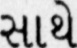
સાથે
